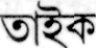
তাইক
